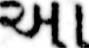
આ
